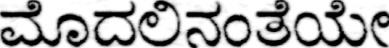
ಮೊದಲಿನಂತೆಯೇ
